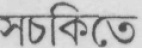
সচকিতে
